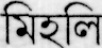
মিহলি
